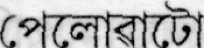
পেলোৱাটো
